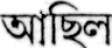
আছিল
